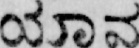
ಯಾವ
